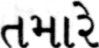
તમારે
